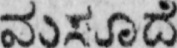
ಮಸೂದೆ
